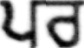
ਪਰ
